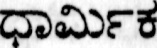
ಧಾರ್ಮಿಕ
